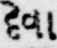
દેવા
